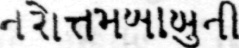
નરોત્તમબાબુની
